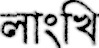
লাংখি
